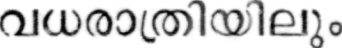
വധരാത്രിയിലും
